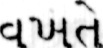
વખતે
